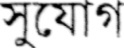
সুযোগ
